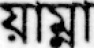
য়াম্না
